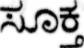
ಸೂಕ್ತ
